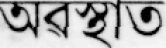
অৱস্থাত
